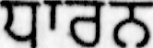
ਧਾਰਨ
